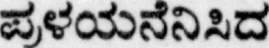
ಪ್ರಳಯನೆನಿಸಿದ
